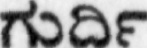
ಗುರ್ದಿ
